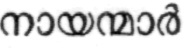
നായന്മാര്‍
